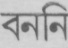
বননি
